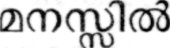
മനസ്സില്‍
